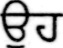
ਉਹ
